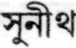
সুনীথ
